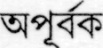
অপূৰ্বক
